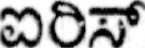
ಐರಿಸ್
